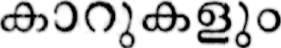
കാറുകളും
